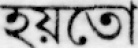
হয়তো
